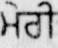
ਮੇਰੀ
